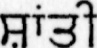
ਸ਼ਾਂਤੀ
